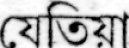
যেতিয়া
